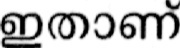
ഇതാണ്
